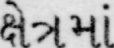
ક્ષેત્રમાં
